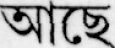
আছে
